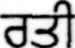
ਰਤੀ
